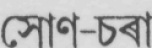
সোণ-চৰা
